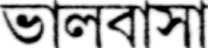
ভালবাসা
